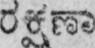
ರಕ್ಷಣಾ
